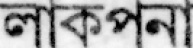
লাকপনা
